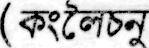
(কংলৈচনু
